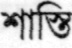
শাস্তি
